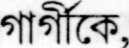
গার্গীকে,
